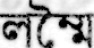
লম্মৈ
